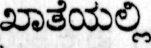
ಖಾತೆಯಲ್ಲಿ
